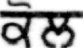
ਕੋਲ
